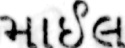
માઈલ
